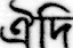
ঐদি
